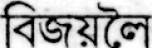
বিজয়লৈ
